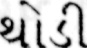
થોડી
